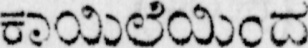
ಕಾಯಿಲೆಯಿಂದ
